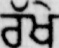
ਰੱਖੇ
